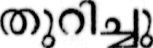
തുറിച്ചു
